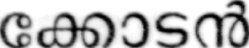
ക്കോടന്‍
